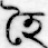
হৈ
